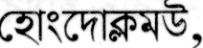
হোংদোক্লমউ,
